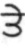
ਤੇ
